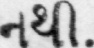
નથી.
